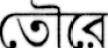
তৌরে
